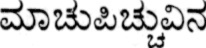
ಮಾಚುಪಿಚ್ಚುವಿನ
